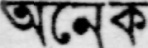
অনেক
